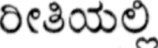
ರೀತಿಯಲ್ಲಿ
